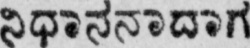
ನಿಧಾನನಾದಾಗ
